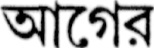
আগের
